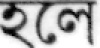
হলে
